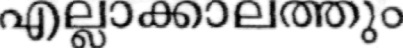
എല്ലാക്കാലത്തും
